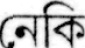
নেকি
